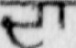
ਦਾ
